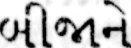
બીજાને
